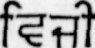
ਵਿਜੀ
